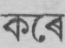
কৰে
